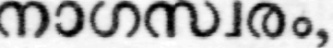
നാഗസ്വരം,
